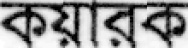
কয়ারক
